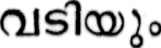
വടിയും
